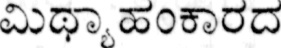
ಮಿಥ್ಯಾಹಂಕಾರದ
